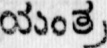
ಯಂತ್ರ
